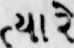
ત્યારે
